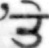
'ਤੇ
